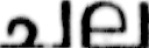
ചല
